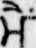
ਮੈਂ
